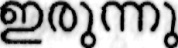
ഇരുന്നു
